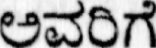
ಅವರಿಗೆ
